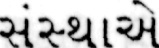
સંસ્થાએ
